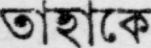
তাহাকে
